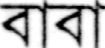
বাবা
